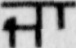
ਜਾ
